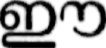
ഈ
